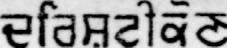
ਦਰਿਸ਼ਟੀਕੋਣ
